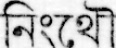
নিংথৌ
